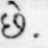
છે.
